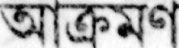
আক্রমণ
